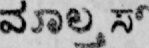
ಮಾಲ್ತಸ್
